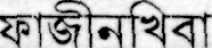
ফাজীনখিবা
